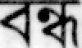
বন্ধ
